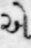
એ
